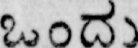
ಒಂದು
